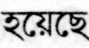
হয়েছে
